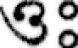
ওঃ
